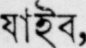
যাইব,
